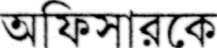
অফিসারকে
